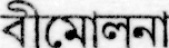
বীমোলনা
